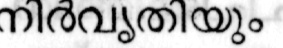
നിര്‍വൃതിയും
